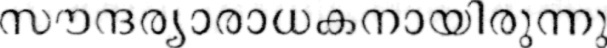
സൌന്ദര്യാരാധകനായിരുന്നു
